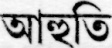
আহুতি
